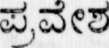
ಪ್ರವೇಶ
